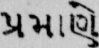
પ્રમાણે
